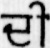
ਦੀ
